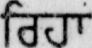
ਰਿਹਾ
